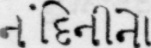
નંદિનીનો
